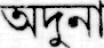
অদুনা
